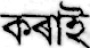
কৰাই
